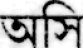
অসি
